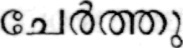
ചേര്‍ത്തു
